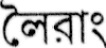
লৈরাং
